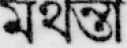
মথন্তা
